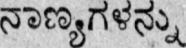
ನಾಣ್ಯಗಳನ್ನು
